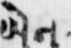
બેન
